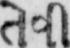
તેવી
